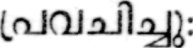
പ്രവചിച്ചു:
